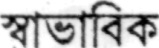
স্বাভাবিক
